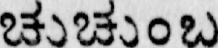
ಚುಚುಂಬ
